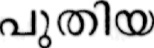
പുതിയ
